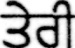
ਤੇਰੀ
